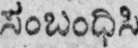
ಸಂಬಂಧಿಸಿ
